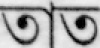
তাত
